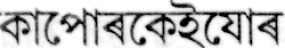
কাপোৰকেইযোৰ
